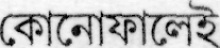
কোনোফালেই
